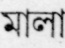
মালা
